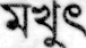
মখুৎ
